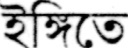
ইঙ্গিতে
